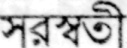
সরস্বতী
